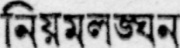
নিয়মলঙ্ঘন
